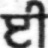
ਈ
